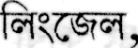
লিংজেল,
